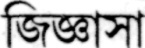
জিজ্ঞাসা
